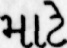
માટે
